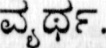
ವ್ಯರ್ಥ.
